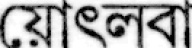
য়োৎলবা
